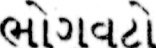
ભોગવટો
